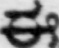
ಈ
